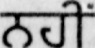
ਨਹੀਂ
